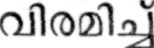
വിരമിച്ച്
